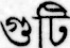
গুটি
